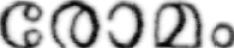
രോമം
